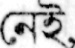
নেই,
